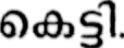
കെട്ടി.
